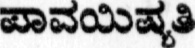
ಪಾವಯಿಷ್ಯತಿ
